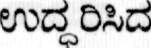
ಉದ್ಧರಿಸಿದ
